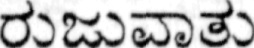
ರುಜುವಾತು
